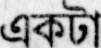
একটা
